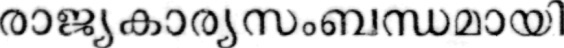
രാജ്യകാര്യസംബന്ധമായി
